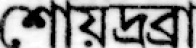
শোয়দ্রব্রা
